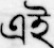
এই
